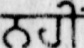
ਨਹੀਂ
